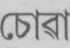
চোৱা
